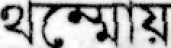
থম্মোয়
